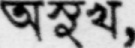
অসুখ,
